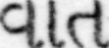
વાત
